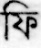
ফি
